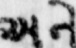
અને
